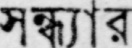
সন্ধ্যার
